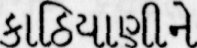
કાઠિયાણીને
